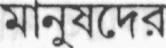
মানুষদের
